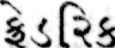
ફ્રેડરિક
